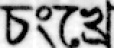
চংখ্রে
